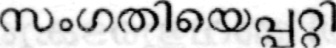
സംഗതിയെപ്പറ്റി
